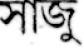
সাজু
